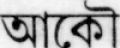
আকৌ
